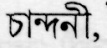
চান্দনী,
